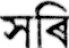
সৰি
